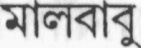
মালবাবু
